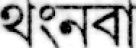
থংনবা
